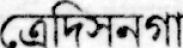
ত্রেদিসনগা
